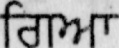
ਗਿਆ
